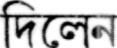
দিলেন
